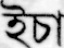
ইচা
